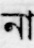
না
